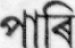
পাৰি
